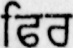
ਫਿਰ
